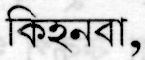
কিহনবা,
